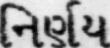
નિર્ણય
